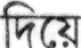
দিয়ে
